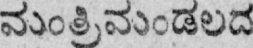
ಮಂತ್ರಿಮಂಡಲದ
